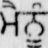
ਮੈਨੂੰ
